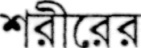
শরীরের
